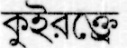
কুইরক্ত্রে
